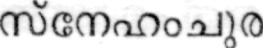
സ്നേഹംചുര
